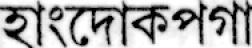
হাংদোকপগা
